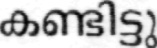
കണ്ടിട്ടു
